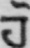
ਹੋ
